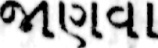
જાણવા
